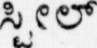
ಸ್ಟೀಲ್
